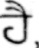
ਹੈ,
